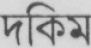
দকিম
